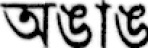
অঙাঙ
